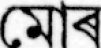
মোৰ
